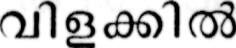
വിളക്കില്‍
